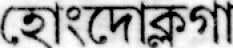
হোংদোক্লগা
